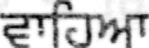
ਵਾਹਿਆ
